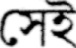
সেই
